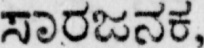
ಸಾರಜನಕ,
